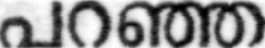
പറഞ്ഞ
